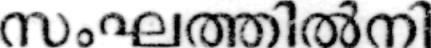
സംഘത്തില്‍നി
